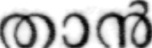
താന്‍
